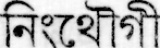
নিংথৌগী
